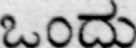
ಒಂದು
